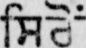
ਸਿਰੋਂ
